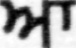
ਆ
